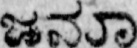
ಜಮಾ
